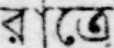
রাত্রে
